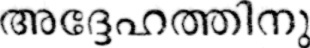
അദ്ദേഹത്തിനു
